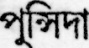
পুন্সিদা
